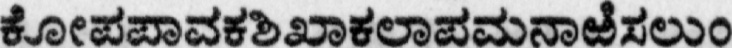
ಕೋಪಪಾವಕಶಿಖಾಕಲಾಪಮನಾಱಸಲುಂ
